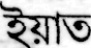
ইয়াত
